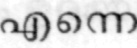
എന്നെ
